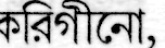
করিগীনো,
